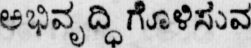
ಅಭಿವೃದ್ಧಿಗೊಳಿಸುವ
